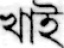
খাই
